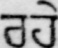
ਰਹੇ
